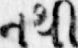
નથી
